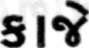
કાજે
